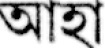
আহা
